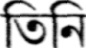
তিনি
